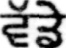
ਵੱਡੇ
